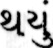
થયું
